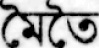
মৈতৈ
